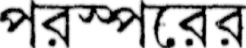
পরস্পরের
